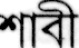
শাবী
